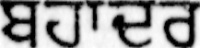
ਬਹਾਦਰ
